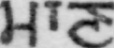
ਮਾਣ
